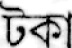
টকা
